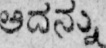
ಅದನ್ನು
